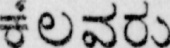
ಕೆಲವರು
